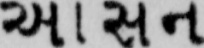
આસન
